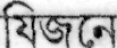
যিজনে
